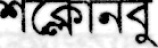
শক্লোনবু
